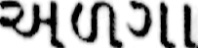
અળગા
